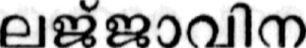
ലജ്ജാവിന
